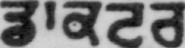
ਡਾਕਟਰ
